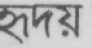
হৃদয়
